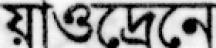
য়াওদ্রেনে
